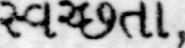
સ્વચ્છતા,
